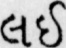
લઈ
